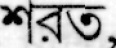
শরত,
